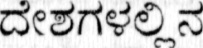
ದೇಶಗಳಲ್ಲಿನ
